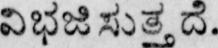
ವಿಭಜಿಸುತ್ತದೆ.
